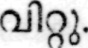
വിറ്റു.
